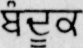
ਬੰਦੂਕ
